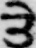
ਤੇ
